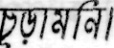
চূড়ামনি।
